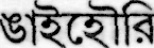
ঙাইহৌরি
